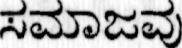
ಸಮಾಜವು
